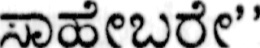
ಸಾಹೇಬರೇ"
